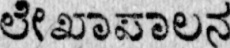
ಲೇಖಾಪಾಲನ
